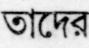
তাদের
